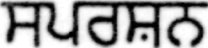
ਸਪਰਸ਼ਨ
